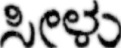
ಸೀಳು
